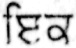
ਇਕ
